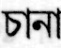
চানা
